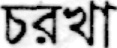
চরখা
